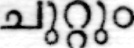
ചുറ്റും
